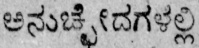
ಅನುಚ್ಛೇದಗಳಲ್ಲಿ
